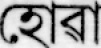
হোৱা
